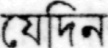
যেদিন
